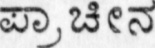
ಪ್ರಾಚೀನ
